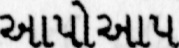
આપોઆપ
